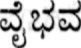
ವೈಭವ
